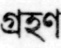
গ্রহণ
